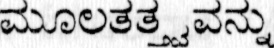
ಮೂಲತತ್ತ್ವವನ್ನು
